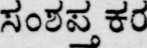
ಸಂಶಪ್ತಕರ
